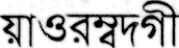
য়াওরম্বদগী
